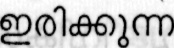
ഇരിക്കുന്ന
